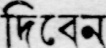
দিবেন
